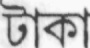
টাকা
